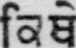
ਕਿਥੇ
